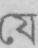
যে
